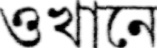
ওখানে
